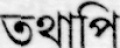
তথাপি
